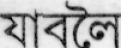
যাবলৈ
